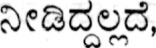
ನೀಡಿದ್ದಲ್ಲದೆ,
